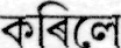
কৰিলে
